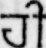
ਹੀ
